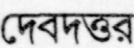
দেবদত্তর
